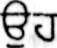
ਉਹ
